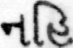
નહિ
